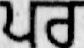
ਪਰ
